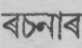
ৰচনাৰ
